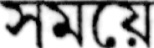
সময়ে
